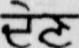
ਦੇਣ
